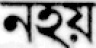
নহয়
